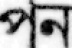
পন
